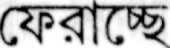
ফেরাচ্ছে
